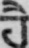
ਹੈ
